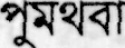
পুমথবা
